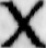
x
